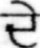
ਦੇ
